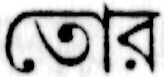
তোর
